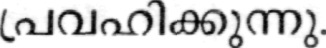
പ്രവഹിക്കുന്നു.
